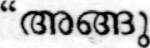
“അങ്ങു
